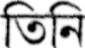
তিনি
